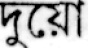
দুয়ো
